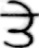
ਤੇ
